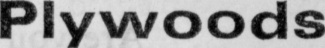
Plywoods
